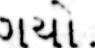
ગયો.
